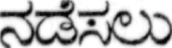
ನಡೆಸಲು
